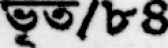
ভুত/৮৪
